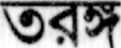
তরঙ্গ
